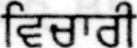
ਵਿਚਾਰੀ
